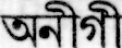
অনীগী
